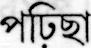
পঢ়িছা
